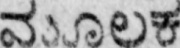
ಮೂಲಕ
